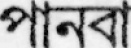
পানবা
